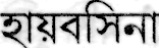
হায়বসিনা
